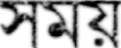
সময়
